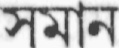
সমান
